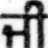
ਜੀ
